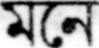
মনে
